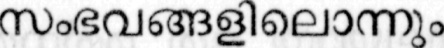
സംഭവങ്ങളിലൊന്നും
